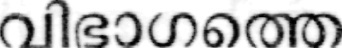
വിഭാഗത്തെ
